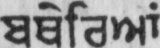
ਬਥੇਰਿਆਂ
